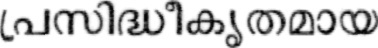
പ്രസിദ്ധീകൃതമായ
